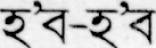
হ'ব-হ'ব
